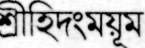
শ্রীহিদংময়ূম
